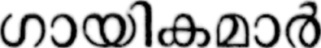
ഗായികമാര്‍
